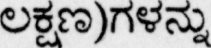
ಲಕ್ಷಣ)ಗಳನ್ನು
